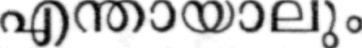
എന്തായാലും
